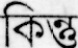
কিন্তু
